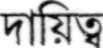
দায়িত্ব
